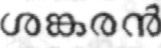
ശങ്കരന്‍
